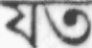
যত
